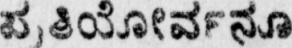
ಪ್ರತಿಯೋರ್ವನೂ
